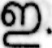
ഇ.
